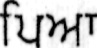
ਪਿਆ
